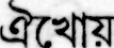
ঐখোয়
